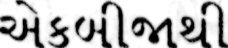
એકબીજાથી
